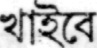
খাইবে
